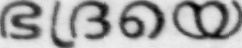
ഭദ്രയെ
